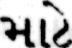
માટે
